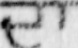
ਦਾ
